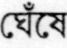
ঘেঁষে
